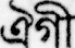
ঐগী
